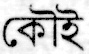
কৌই
